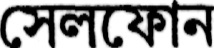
সেলফোন
